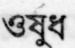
ওষুধ
